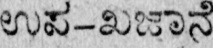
ಉಪ-ಖಜಾನೆ
